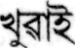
খুৱাই
